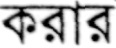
করার
